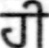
ਹੀ
